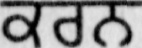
ਕਰਨ
